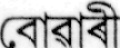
বোৱাৰী
